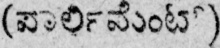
(ಪಾರ್ಲಿಮೆಂಟ್)
